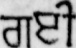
ਗਈ
